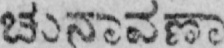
ಚುನಾವಣಾ
